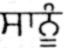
ਸਾਨੂੰ
